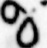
જ
